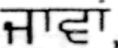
ਜਾਵਾਂ,
